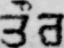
ਤੌਰ
